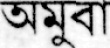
অমুবা
